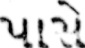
પાસે
